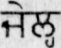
ਜੇਲ੍ਹ
